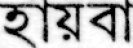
হায়বা
